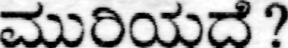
ಮುರಿಯದೆ?
